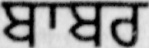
ਬਾਬਰ
